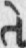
તે
